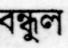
বন্ধুল
